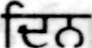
ਦਿਨ
